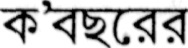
ক’বছরের
